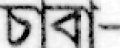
চাবা-
